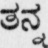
ತನ್ನ
